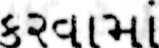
કરવામાં
